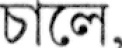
চালে,
